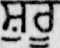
ਸ਼ੁਰੂ
